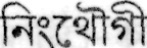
নিংথৌগী
